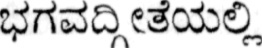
ಭಗವದ್ಗೀತೆಯಲ್ಲಿ
